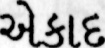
એકાદ
